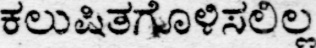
ಕಲುಷಿತಗೊಳಿಸಲಿಲ್ಲ
